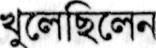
খুলেছিলেন
